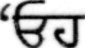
'ਓਹ
